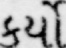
કર્યો
